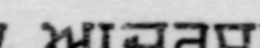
ਆਦਰਸ
